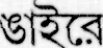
ঙাইরে
